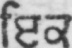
ਇਕ
